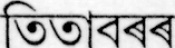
তিতাবৰৰ
